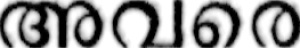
അവരെ
